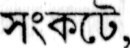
সংকটে,
